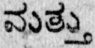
ಮತ್ತು
